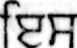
ਇਸ
